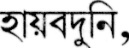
হায়বদুনি,
